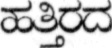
ಹತ್ತಿರದ
